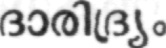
ദാരിദ്ര്യം
